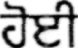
ਹੋਈ
